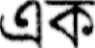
এক
